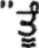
''ਤੂੰ
